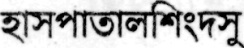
হাসপাতালশিংদসু
